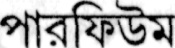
পারফিউম
